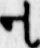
ન
